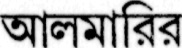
আলমারির
